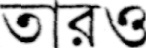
তারও
